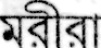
মরীরা
